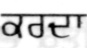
ਕਰਦਾ
